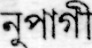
নুপাগী
